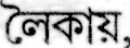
লৈকায়,
